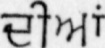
ਦੀਆਂ
